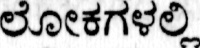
ಲೋಕಗಳಲ್ಲಿ
